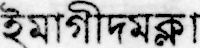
ইমাগীদমক্লা
